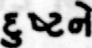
દુષ્ટને
